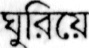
ঘুরিয়ে
